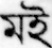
মই
